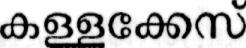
കള്ളക്കേസ്
